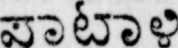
ಪಾಟಾಳಿ
